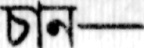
চান-
